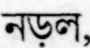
নড়ল,
